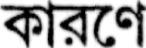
কারণে
